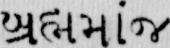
બ્રહ્મમાંજ
